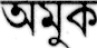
অমুক
